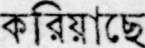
করিয়াছে
